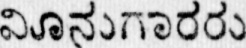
ಮೀನುಗಾರರು
